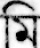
মি
